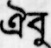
ঐবু
